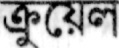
ক্রুয়েল
